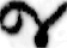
જ
